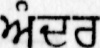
ਅੰਦਰ
